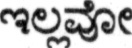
ಇಲ್ಲವೋ
